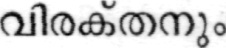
വിരക്തനും
